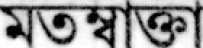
মতম্বাক্তা
